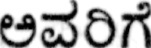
ಅವರಿಗೆ
